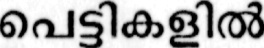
പെട്ടികളില്‍
